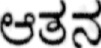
ಆತನ
